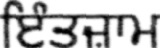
ਇੰਤਜ਼ਾਮ
